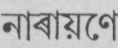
নাৰায়ণে
